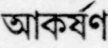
আকর্ষণ
